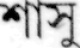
শাসু
